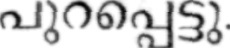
പുറപ്പെട്ടു.
